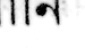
ৱানি
